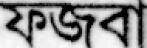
ফজবা
